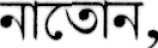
নাতোন,
